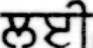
ਲਈ
